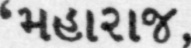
'મહારાજ,
